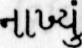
નાખ્યું
